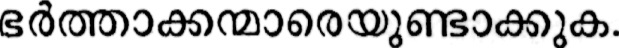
ഭര്‍ത്താക്കന്മാരെയുണ്ടാക്കുക.
